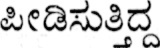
ಪೀಡಿಸುತ್ತಿದ್ದ
